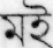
মই
